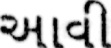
આવી
